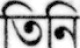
তিনি
